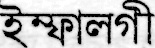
ইম্ফালগী
